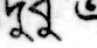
দুবু
